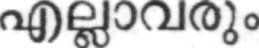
എല്ലാവരും
